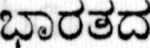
ಭಾರತದ
